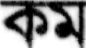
কম
